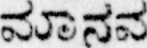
ಮಾನವ
